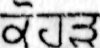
ਕੋਹੜ
